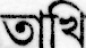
তাখি
